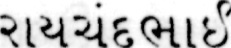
રાયચંદભાઈ
